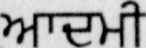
ਆਦਮੀ
